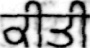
ਕੀਤੀ
